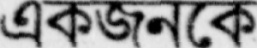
একজনকে
